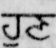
ਹੁਣ
